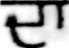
ਦਾ
